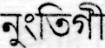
নুংতিগী
